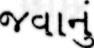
જવાનું
